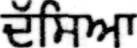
ਦੱਸਿਆ
